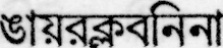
ঙায়রক্লবনিনা
